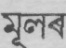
মূলৰ
